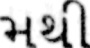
મથી
